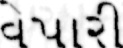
વેપારી
